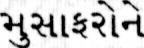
મુસાફરોને
